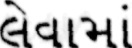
લેવામાં
